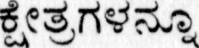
ಕ್ಷೇತ್ರಗಳನ್ನೂ
